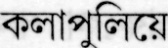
কলাপুলিয়ে
